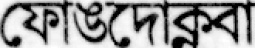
ফোঙদোক্নবা
